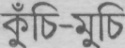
কুঁচি-মুচি
